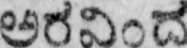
ಅರವಿಂದ
